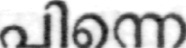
പിന്നെ
